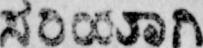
ಸರಿಯಾಗಿ
